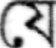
যে
